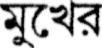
মুখের
